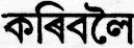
কৰিবলৈ
